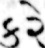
કરે
